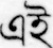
এই
